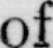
of
